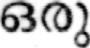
ഒരു
